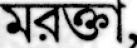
মরক্তা,
